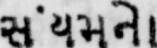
સંયમનો
